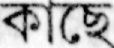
কাছে
